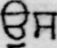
ਉਸ
